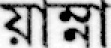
য়াম্না
